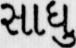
સાધુ
